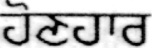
ਹੋਣਹਾਰ
